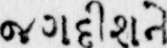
જગદીશને
